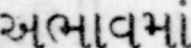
અભાવમાં
